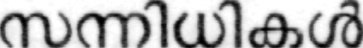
സന്നിധികള്‍
